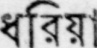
ধরিয়া
